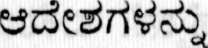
ಆದೇಶಗಳನ್ನು
